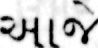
આજે
